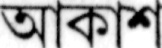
আকাশ
